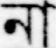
না
